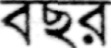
বছর
